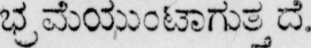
ಭ್ರಮೆಯುಂಟಾಗುತ್ತದೆ.
